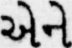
એને
